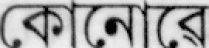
কোনোৱে
